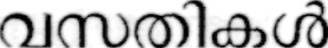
വസതികള്‍
